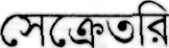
সেক্রেতরি
